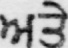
ਅਤੇ
